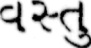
વસ્તુ
